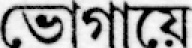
ভোগায়ে
